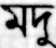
মদু
